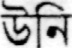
উনি
